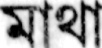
মাথা
